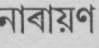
নাৰায়ণ
